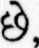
છે,
